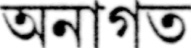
অনাগত
